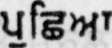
ਪੁਛਿਆ
